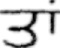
ਤਾਂ
